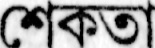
শেকতা
